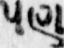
પણ
